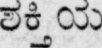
ಶಕ್ತಿಯ
